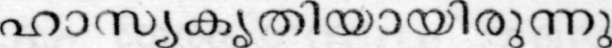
ഹാസ്യകൃതിയായിരുന്നു
